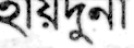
হায়দুনা
